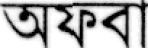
অফবা
